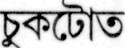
চুকটোত
